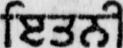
ਇਤਨੀ
